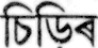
চিড়িৰ
